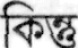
কিন্তু
